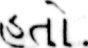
હતો.
